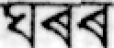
ঘৰৰ
